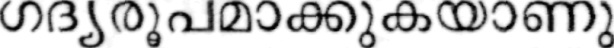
ഗദ്യരൂപമാക്കുകയാണു
